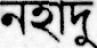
নহাদু
